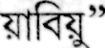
য়াবিয়ু”
